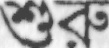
শুরু
